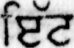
ਇੱਟ
